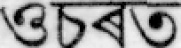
ওচৰত
